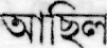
আছিল
